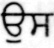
ਉਸ
